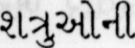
શત્રુઓની
